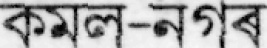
কমল-নগৰ
